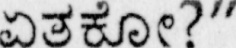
ಏತಕೋ?”
